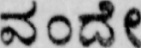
ವಂದೇ
